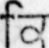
ਕਿ
